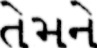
તેમને
